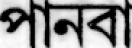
পানবা
